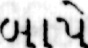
બાપે
